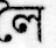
লৈ
